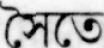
সৈতে
